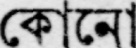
কোনো
